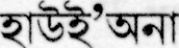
হাউই’অনা
